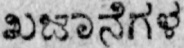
ಖಜಾನೆಗಳ
